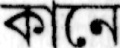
কানে
